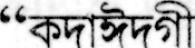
“কদাঈদগী
